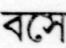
বসে
